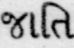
જાતિ
